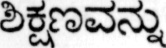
ಶಿಕ್ಷಣವನ್ನು
